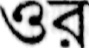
ওর
